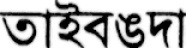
তাইবঙদা
